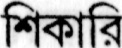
শিকারি
